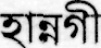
হান্নগী
